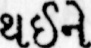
થઈને
